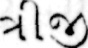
ત્રીજી
